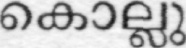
കൊല്ലു
